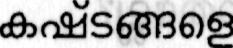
കഷ്ടങ്ങളെ
